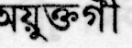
অয়ুক্তগী
